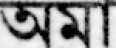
অমা
